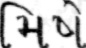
મિષે
